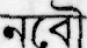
নবৌ
